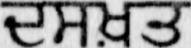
ਦਸਖ਼ਤ
